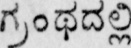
ಗ್ರಂಥದಲ್ಲಿ
